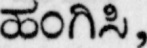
ಹಂಗಿಸಿ,
